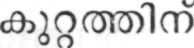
കുറ്റത്തിന്
